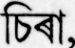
চিৰা,
